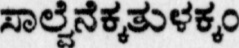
ಸಾಲ್ವೆನೆಕ್ಕತುಳಕ್ಕಂ
